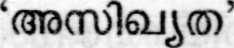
‘അസിഖ്യത'
